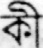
কী
